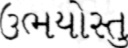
ઉભયોસ્તુ
